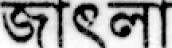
জাৎলা
